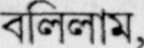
বলিলাম,
